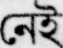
নেই
